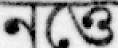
নত্তে
